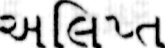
અલિપ્ત
